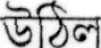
উঠিল
